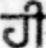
ਹੀ
